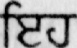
ਇਹ
